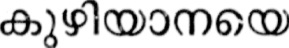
കുഴിയാനയെ
